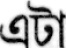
এটা
